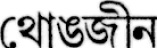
থোঙজীন
